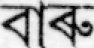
বাৰু
